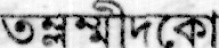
তম্লম্মীদকো
